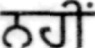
ਨਹੀਂ
